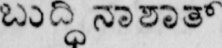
ಬುದ್ಧಿನಾಶಾತ್
